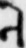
ને
